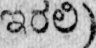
ಇರಲಿ)
